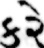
કરે
